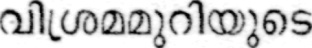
വിശ്രമമുറിയുടെ
